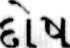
દોષ
